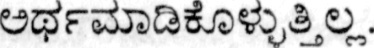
ಅರ್ಥಮಾಡಿಕೊಳ್ಳುತ್ತಿಲ್ಲ.
